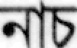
নাচ
